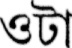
ওটা
